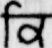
ਕਿ
